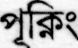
পূক্নিং
